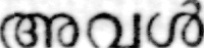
അവള്‍
